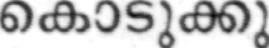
കൊടുക്കു
